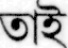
তাই
